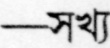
–সখ্য
